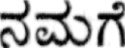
ನಮಗೆ
